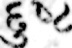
દુષ્ટ
